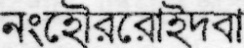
নংহৌররোইদবা
